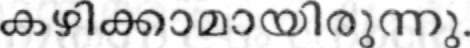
കഴിക്കാമായിരുന്നു.
